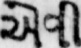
એવી
